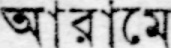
আরামে
